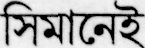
সিমানেই
